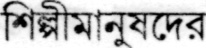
শিল্পীমানুষদের
